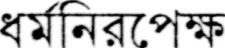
ধর্মনিরপেক্ষ
